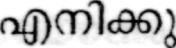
എനിക്കു
